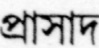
প্রাসাদ
